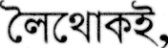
লৈথোকই,
